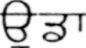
ਉਡਾ
